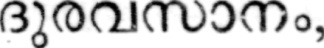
ദുരവസാനം,
